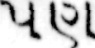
પણ
